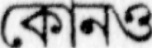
কোনও
